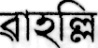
ৱাহল্লি
